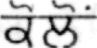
ਕੋਲੋਂ
